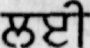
ਲਈ
